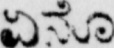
ಏನೊ
